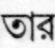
তার
